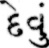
દેવું
